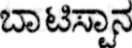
ಬಾಟಿಸ್ಟಾನ
